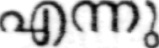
എന്നു
